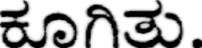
ಕೂಗಿತು.
